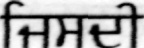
ਜਿਸਦੀ
